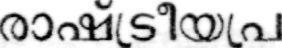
രാഷ്ട്രീയപ്ര
